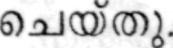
ചെയ്തു.
